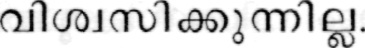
വിശ്വസിക്കുന്നില്ല.
